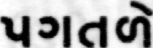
પગતળે
